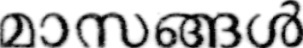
മാസങ്ങള്‍
